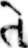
તે
